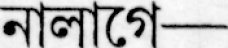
নালাগে-
